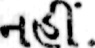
નહીં.
